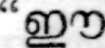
“ഈ
